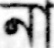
না
